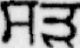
ਸੜ
